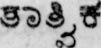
ತಾತ್ವಿಕ
